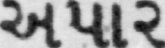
અપાર
